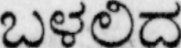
ಬಳಲಿದ
